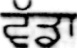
ਵੱਡਾ
